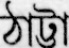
ঠাট্টা
